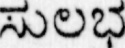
ಸುಲಭ
